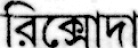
রিক্সোদা
